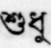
শুধু
